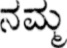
ನಮ್ಮ
